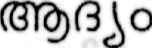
ആദ്യം
